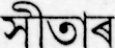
সীতাৰ
